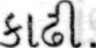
કાઢી.
